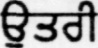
ਉਤਰੀ
